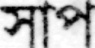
সাপ
